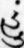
હું
